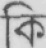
কি
